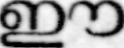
ഈ
